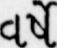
વર્ષે
